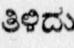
ತಿಳಿದು
